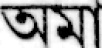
অমা
